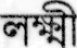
লক্ষ্মী
